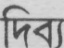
দিব্য
